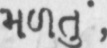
મળતું,
